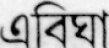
এবিঘা
